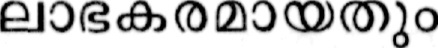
ലാഭകരമായതും
